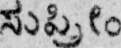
ಸುಪ್ರೀಂ
